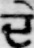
ਦੇ
